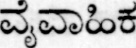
ವೈವಾಹಿಕ
